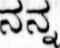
ನನ್ನ
